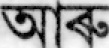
আৰু
